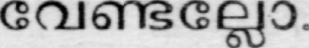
വേണ്ടല്ലോ.
